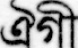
ঐগী
